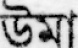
উমা
